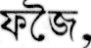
ফজৈ,
